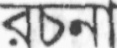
রচনা
